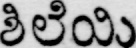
ಶಿಲೆಯಿ
